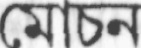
মোচন
